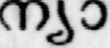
ന്യാ
